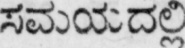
ಸಮಯದಲ್ಲಿ
